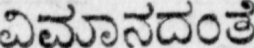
ವಿಮಾನದಂತೆ
